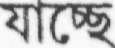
যাচ্ছে
